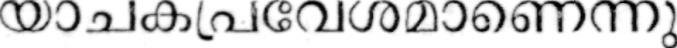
യാചകപ്രവേശമാണെന്നു
